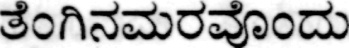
ತೆಂಗಿನಮರವೊಂದು
